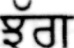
ਝੱਗ
